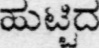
ಹುಟ್ಟಿದ
